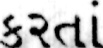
કરતાં
